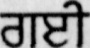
ਗਈ
